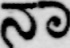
ನಾ
